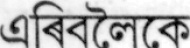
এৰিবলৈকে
